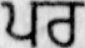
ਪਰ
